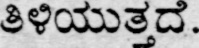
ತಿಳಿಯುತ್ತದೆ.
